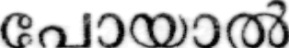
പോയാല്‍
